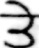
ਤੇ
